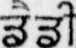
ਡੈਡੀ
